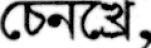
চেনখ্রে
